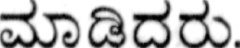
ಮಾಡಿದರು.
